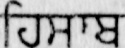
ਹਿਸਾਬ
